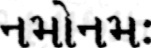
નમોનમઃ
